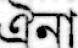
ঐনা
